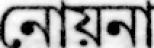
নোয়না
